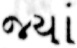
જ્યાં
